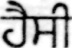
ਹੈਸੀ
